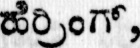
ಹೆರ್ರಿಂಗ್,
